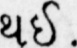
થઈ.
